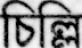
চিল্লি
